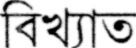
বিখ্যাত
